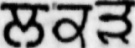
ਲਕੜ
